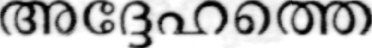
അദ്ദേഹത്തെ
